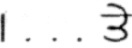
।......ਤੇ
